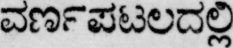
ವರ್ಣಪಟಲದಲ್ಲಿ
